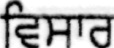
ਵਿਸਾਰ
